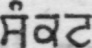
ਸੰਕਟ
